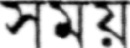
সময়
